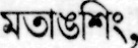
মতাঙশিং,
